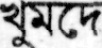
খুমদে
